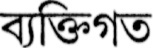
ব্যক্তিগত
